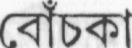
বোঁচকা
